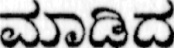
ಮಾಡಿದ
